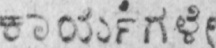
ಕಾರ್ಯಗಳೇ
